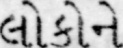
લોકોને
